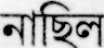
নাছিল
